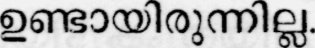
ഉണ്ടായിരുന്നില്ല.
